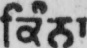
ਕਿੰਨਾ
